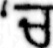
'ਚ
